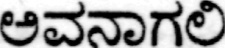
ಅವನಾಗಲಿ
